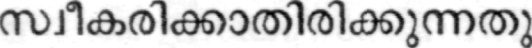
സ്വീകരിക്കാതിരിക്കുന്നതു
